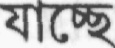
যাচ্ছে
